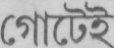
গোটেই
